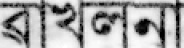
ৱাখলনা
